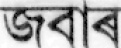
জবাৰ
